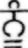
ਨੂੰ
